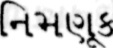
નિમણૂક
